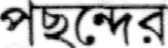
পছন্দের
